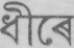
ধীৰে
